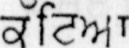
ਕੱਟਿਆ
